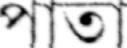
পাতা
